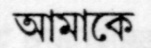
আমাকে
